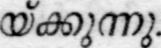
യ്ക്കുന്നു.
